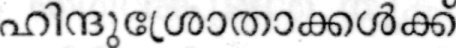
ഹിന്ദുശ്രോതാക്കള്‍ക്ക്
